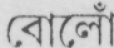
বোলোঁ
